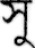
সু
